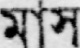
মাস
